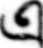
এ
